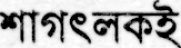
শাগৎলকই
